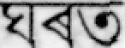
ঘৰত
